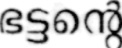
ഭട്ടന്റെ
